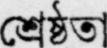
শ্রেষ্ঠতা
